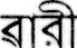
ৱারী
